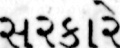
સરકારે
